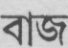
বাজ
